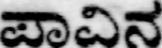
ಪಾವಿನ
